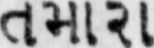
તમારા
